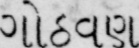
ગોઠવણ
